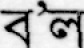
ব'ল
